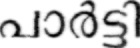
പാര്‍ട്ടി
